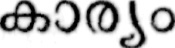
കാര്യം
